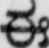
ಈ
